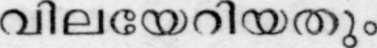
വിലയേറിയതും
